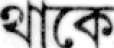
থাকে
